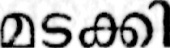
മടക്കി
